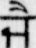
ਜੈ
